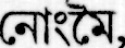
নোংমৈ,
